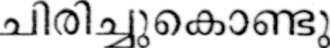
ചിരിച്ചുകൊണ്ടു
